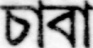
চাবা
